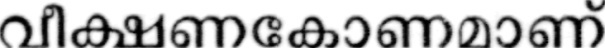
വീക്ഷണകോണമാണ്
